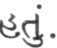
હતું.
